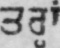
ਤਰ੍ਹਾਂ
